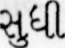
સુધી
